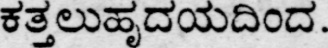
ಕತ್ತಲುಹೃದಯದಿಂದ.
